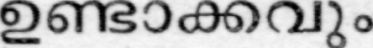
ഉണ്ടാക്കവും
